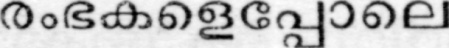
രംഭകളെപ്പോലെ
